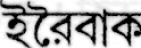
ইরৈবাক
